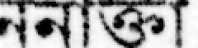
ননাক্তা
